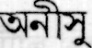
অনীসু
